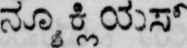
ನ್ಯೂಕ್ಲಿಯಸ್
